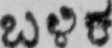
ಬಳಿಕ
